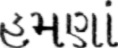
હમણાં
